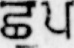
ਛੁਪ
